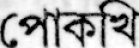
পোকখি
